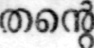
തന്റെ
